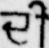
ਦੀ
